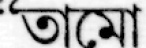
“তামো
